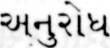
અનુરોધ
